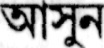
আসুন
